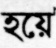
হয়ে
